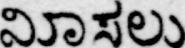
ಮೀಸಲು
